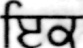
ਇਕ
